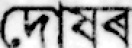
দোষৰ
